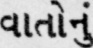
વાતોનું
